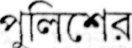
পুলিশের
